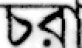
চরা
